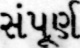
સંપૂર્ણ
